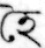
হৈ
